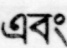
এবং
